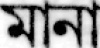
মানা
